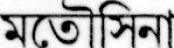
মতৌসিনা
